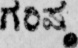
ಗರಿಷ್ಟ
